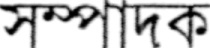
সম্পাদক
